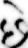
છે
